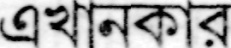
এখানকার
